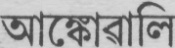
আঙ্কোৱালি
